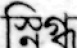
স্নিগ্ধ
